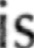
is
